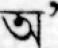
অ'
